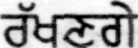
ਰੱਖਣਗੇ
